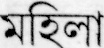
মহিলা
